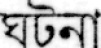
ঘটনা
